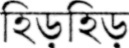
হিড়হিড়
